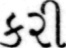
કરી
